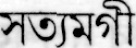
সত্যমগী
